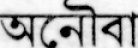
অনৌবা
